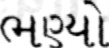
ભણ્યો
